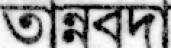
তান্নবদা
